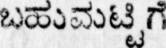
ಬಹುಮಟ್ಟಿಗೆ
